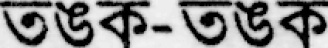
তঙক-তঙক
